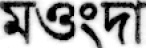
মওংদা
